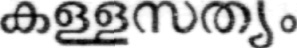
കള്ളസത്യം
